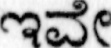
ಇವೇ
